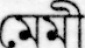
মেমী
